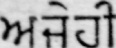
ਅਜੇਹੀ
